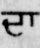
ਦਾ
